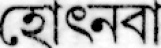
হোৎনবা
